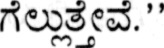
ಗೆಲ್ಲುತ್ತೇವೆ."
